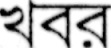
খবর
